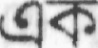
এক
